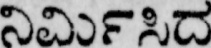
ನಿರ್ಮಿಸಿದ
